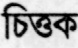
চিত্তক
